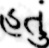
હતું
